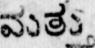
ಮತ್ತು
